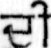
ਦੀ
